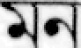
মন
